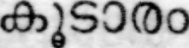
കൂടാരം
